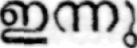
ഇന്നു
